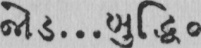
જોડ...બુદ્ધિ.
